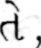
તે,
